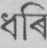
ধৰি
